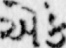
એક
